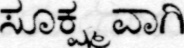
ಸೂಕ್ಷ್ಮವಾಗಿ
